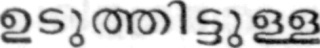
ഉടുത്തിട്ടുള്ള
